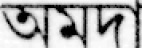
অমদা
